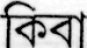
কিবা
